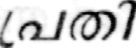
പ്രതി
